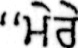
''ਮੇਰੇ
